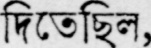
দিতেছিল,
